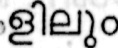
ളിലും
